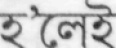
হ'লেই
